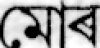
মোৰ
